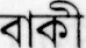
বাকী
